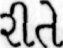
રીતે
